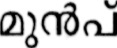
മുന്‍പ്
